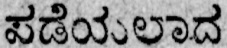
ಪಡೆಯಲಾದ
